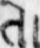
તો
